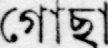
গোছা
